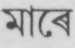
মাৰে
